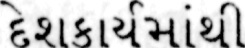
દેશકાર્યમાંથી
